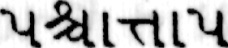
પશ્ચાત્તાપ
